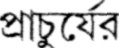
প্রাচুর্যের
